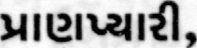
પ્રાણપ્યારી,
